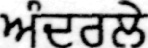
ਅੰਦਰਲੇ
